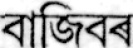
বাজিবৰ
